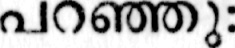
പറഞ്ഞു:
